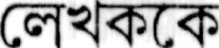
লেখককে
